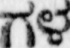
ಗಳ
